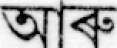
আৰু
